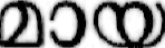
മായ
